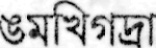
ঙমখিগদ্রা
